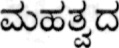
ಮಹತ್ವದ
